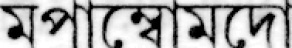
মপাম্বোমদো
